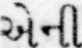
એની
